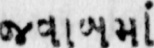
જવાબમાં
